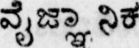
ವೈಜ್ಞಾನಿಕ
